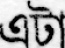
এটা
